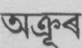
অক্ৰূৰ
